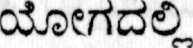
ಯೋಗದಲ್ಲಿ
